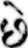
છે
